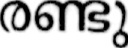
രണ്ടു
